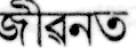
জীৱনত
